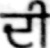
ਦੀ
